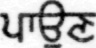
ਪਾਉਣ
